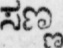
ಸಣ್ಣ
